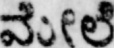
ಮೇಲೆ
